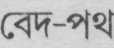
বেদ-পথ
